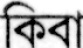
কিবা
